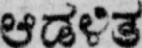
ಆಡಳಿತ
